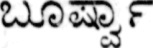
ಬೂರ್ಷ್ವಾ
